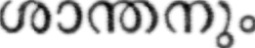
ശാന്തനും
